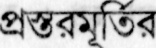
প্রস্তরমূর্তির
